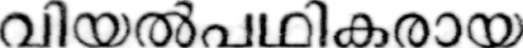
വിയല്‍പഥികരായ
